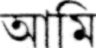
আমি
